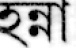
হন্না
